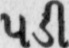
પડી
